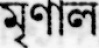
মৃণাল
